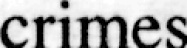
crimes
